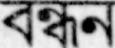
বন্ধন
